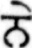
ਨੇ
